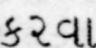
કરવા
